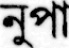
নুপা
